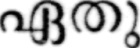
ഏതു
